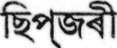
ছিপ্জৰী
